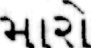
મારો
